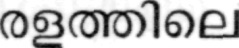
രളത്തിലെ
